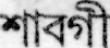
শাবগী
